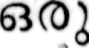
ഒരു
